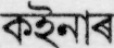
কইনাৰ
